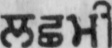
ਲਛਮੀ
